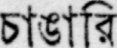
চাঙারি
